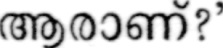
ആരാണ്?’
